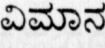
ವಿಮಾನ
